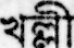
খল্লী
